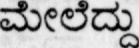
ಮೇಲೆದ್ದು
